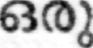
ഒരു
